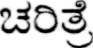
ಚರಿತ್ರೆ
